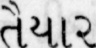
તૈયાર
